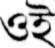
ওই
